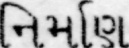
નિર્માણ
